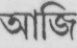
আজি
